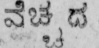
ವೆಚ್ಚದ
